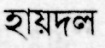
হায়দল
